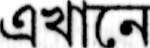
এখানে
